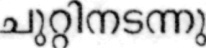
ചുറ്റിനടന്നു
